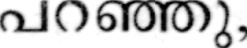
പറഞ്ഞു,
